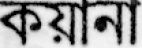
কয়ানা
